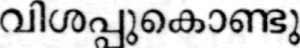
വിശപ്പുകൊണ്ടു
